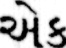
એક
